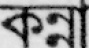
কন্না
